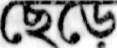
ছেড়ে
